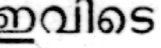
ഇവിടെ
